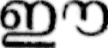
ഈ
